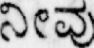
ನೀವು
